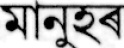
মানুহৰ
